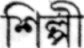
শিল্পী
